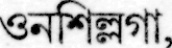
ওনশিল্লগা,
